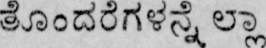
ತೊಂದರೆಗಳನ್ನೆಲ್ಲಾ
